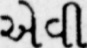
એવી
